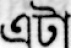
এটা
